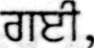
ਗਈ,
